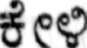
ಕೇಳಿ
